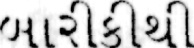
બારીકીથી
